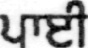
ਪਾਈ
